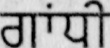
ਗਾਂਧੀ
